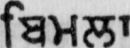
ਬਿਮਲਾ
